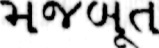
મજબૂત
